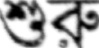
শুরু
